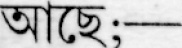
আছে;-
